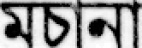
মচানা
